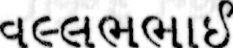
વલ્લભભાઈ
